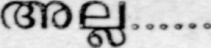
അല്ല......
